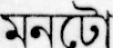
মনটো
